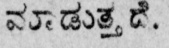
ಮಾಡುತ್ತದೆ.
